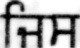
ਜਿਸ
